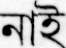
নাই
